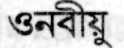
ওনবীয়ু
